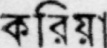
করিয়া
